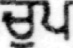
ਚੁਪ
